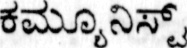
ಕಮ್ಯೂನಿಸ್ಟ್
